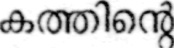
കത്തിന്റെ
